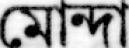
মোন্দা
